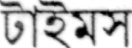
টাইমস
